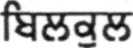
ਬਿਲਕੁਲ
